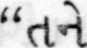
"તને
